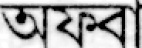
অফবা
